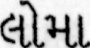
લોમા
